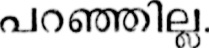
പറഞ്ഞില്ല.
